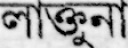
লাক্তুনা
